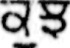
ਕੁਝ
